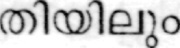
തിയിലും
